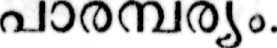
പാരമ്പര്യം.
